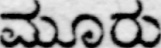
ಮೂರು
